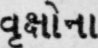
વૃક્ષોના
